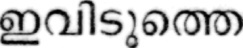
ഇവിടുത്തെ
